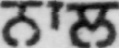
ਨਾਲ
